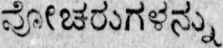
ವೋಚರುಗಳನ್ನು
